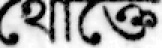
থোক্তে
